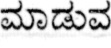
ಮಾಡುವ
